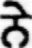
ਨੇ
